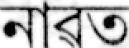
নাৱত
